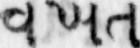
વખત
